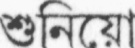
শুনিয়ো
